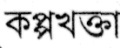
কপ্পখক্তা
